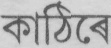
কাঠিৰে
